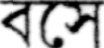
বসে
